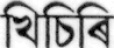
খিচিৰি
